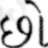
છો
